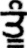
ਤੂੰ
